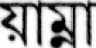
য়াম্না
